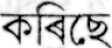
কৰিছে
